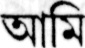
আমি
